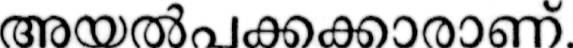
അയല്‍പക്കക്കാരാണ്.
